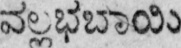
ವಲ್ಲಭಬಾಯಿ
